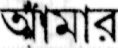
আমার
